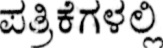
ಪತ್ರಿಕೆಗಳಲ್ಲಿ
